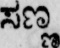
ಸಣ್ಣ
